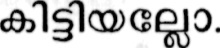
കിട്ടിയല്ലോ.
